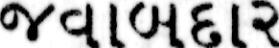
જવાબદાર
